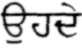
ਉਹਦੇ
